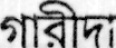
গারীদা
